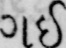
ગઈ
